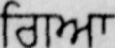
ਗਿਆ
